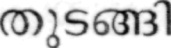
തുടങ്ങി
